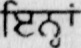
ਇਨ੍ਹਾਂ
